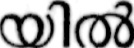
യില്‍
